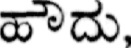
ಹೌದು,
